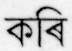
কৰি
